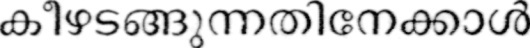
കീഴടങ്ങുന്നതിനേക്കാള്‍
